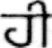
ਹੀ
